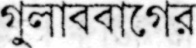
গুলাববাগের
